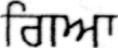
ਗਿਆ
